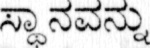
ಸ್ಥಾನವನ್ನು
